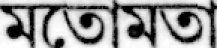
মতোমতা
